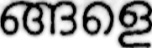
ങ്ങളെ
